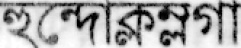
হুন্দোক্লম্লগা
